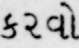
કરવો
